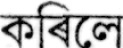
কৰিলে
